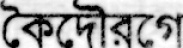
কৈদৌরগে
